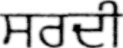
ਸਰਦੀ
